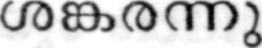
ശങ്കരന്നു
